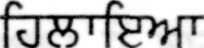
ਹਿਲਾਇਆ
